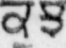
ਕੁਝ
